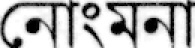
নোংমনা
